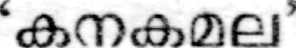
‘കനകമല’
